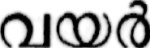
വയര്‍
